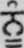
ਨੂੰ
